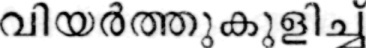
വിയര്‍ത്തുകുളിച്ച്
